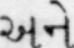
અને
